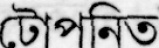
টোপনিত
